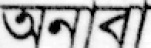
অনাবা
